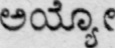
ಅಯ್ಯೋ
